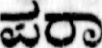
ಪರಾ
